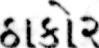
ઠાકોર
